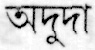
অদুদা
